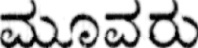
ಮೂವರು
